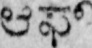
ಆಫ್
